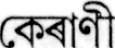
কেৰাণী
